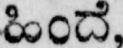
ಹಿಂದೆ,
